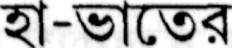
হা-ভাতের
